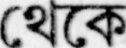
থেকে
